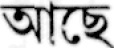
আছে
